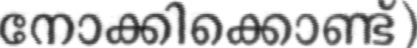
നോക്കിക്കൊണ്ട്)
